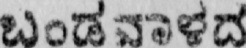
ಬಂಡವಾಳದ
